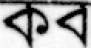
কব
